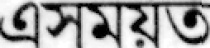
এসময়ত
